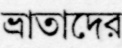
ভ্রাতাদের
